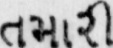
તમારી
